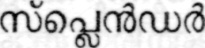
സ്പ്ലെന്‍ഡര്‍
